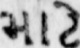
માટે
